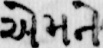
એમને
